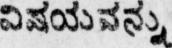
ವಿಷಯವನ್ನು
